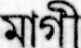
মাগী
